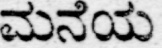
ಮನೆಯ
